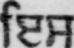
ਇਸ
